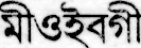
মীওইবগী
